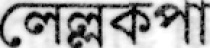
লেল্লকপা
